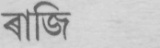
ৰাজি
